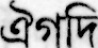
ঐগদি
